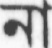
না
